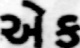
એક
